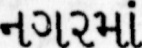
નગરમાં
